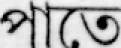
পাতে
